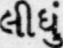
લીધું
